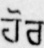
ਹੋਰ
